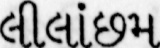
લીલાંછમ
